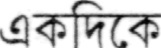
একদিকে
